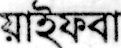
য়াইফবা
